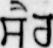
ਸੈਰ
